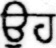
ਉਹ
